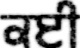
ਕਈ
